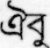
ঐবু
